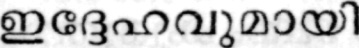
ഇദ്ദേഹവുമായി
